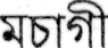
মচাগী
